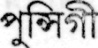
পুন্সিগী
